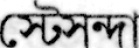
স্টেসন্দা
